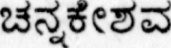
ಚನ್ನಕೇಶವ
